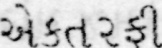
એકતરફી
